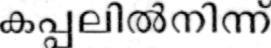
കപ്പലില്‍നിന്ന്
